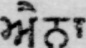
ਐਨਾ
